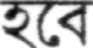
হবে
